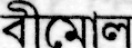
বীমোল
